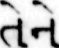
તેને
